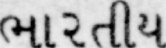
ભારતીય
